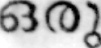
ഒരു
